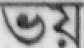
ভয়
